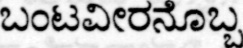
ಬಂಟವೀರನೊಬ್ಬ
